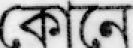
কোনে
